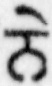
ਨੇ
